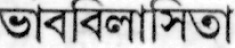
ভাববিলাসিতা
